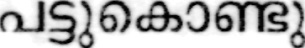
പട്ടുകൊണ്ടു
